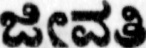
ಜೀವತಿ
